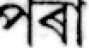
পৰা
